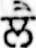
ਲੈ
